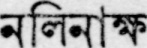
নলিনাক্ষ
